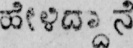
ಹೇಳಿದ್ದಾನೆ
